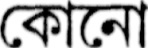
কোনো
